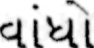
વાંધો
